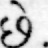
છે.
